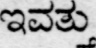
ಇವತ್ತು
